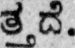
ತ್ತದೆ.
